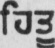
ਹਿਤੂ
